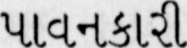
પાવનકારી
